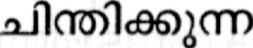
ചിന്തിക്കുന്ന
